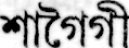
শাগৈগী
